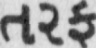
તરફ
